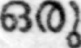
ഒരു
